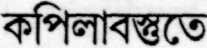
কপিলাবস্তুতে
